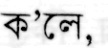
ক'লে,
